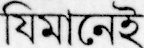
যিমানেই
